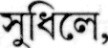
সুধিলে,
